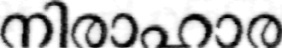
നിരാഹാര
